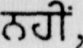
ਨਹੀਂ,
